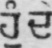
ਹੁੰਦੇ
